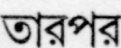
তারপর
